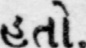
હતો.
